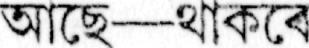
আছে–থাকবে
